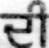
ਦੀ
